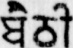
ਬੈਠੀ
